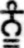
ਨੂੰ
